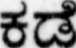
ಕಡೆ
